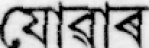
যোৱাৰ
